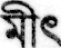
মীৎ
